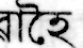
ৱাহৈ
